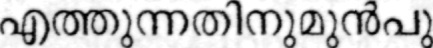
എത്തുന്നതിനുമുന്‍പു
